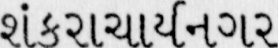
શંકરાચાર્યનગર
